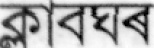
ক্লাবঘৰ
